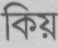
কিয়
